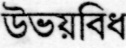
উভয়বিধ
